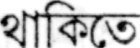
থাকিতে
